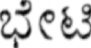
ಭೇಟಿ
